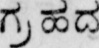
ಗ್ರಹದ
